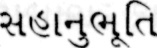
સહાનુભૂતિ
